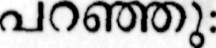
പറഞ്ഞു:
